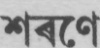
শৰণে
